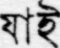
যাই
